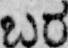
ಬರ
